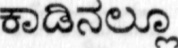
ಕಾಡಿನಲ್ಲೂ
